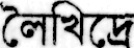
লৈখিদ্রে
